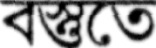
বস্তুতে
